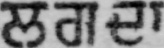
ਲਗਦਾ
